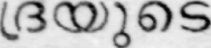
ദ്രയുടെ
